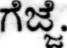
ಗೆಜ್ಜೆ.
